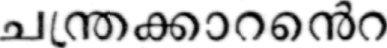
ചന്ത്രക്കാറന്റെ
